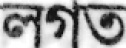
লগত
